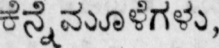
ಕೆನ್ನೆಮೂಳೆಗಳು,
